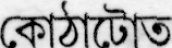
কোঠাটোত
